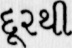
દૂરથી
